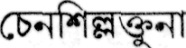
চেনশিল্লক্তুনা
